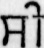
ਸੀ
